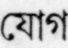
যোগ
